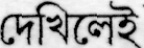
দেখিলেই
